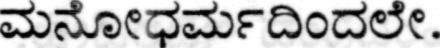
ಮನೋಧರ್ಮದಿಂದಲೇ.
